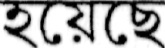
হয়েছে
